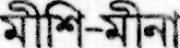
মীশি-মীনা
